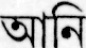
আনি
